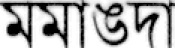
মমাঙদা
